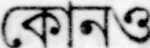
কোনও
